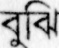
বুঝি
